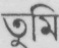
তুমি
